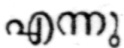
എന്നു
